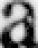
a
